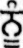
ਨੂੰ
